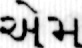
એમ
